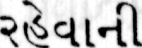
રહેવાની
